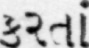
કરતાં
